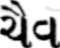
ચૈવ
